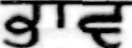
ਭਾਵ
